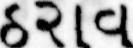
ઠરાવ
